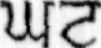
ਘਟ
